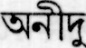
অনীদু
